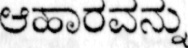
ಆಹಾರವನ್ನು
